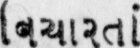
વિચારતાં
